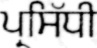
ਪ੍ਰਸਿੱਧੀ
